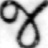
જ
